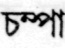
চম্পা
